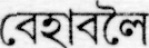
বেহাবলৈ
